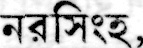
নরসিংহ,
